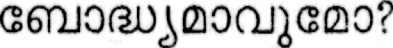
ബോദ്ധ്യമാവുമോ?
